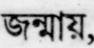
জন্মায়,
